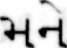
મને
